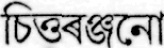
চিত্তৰঞ্জনো
